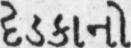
દેડકાનો
